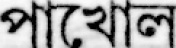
পাখোল
